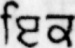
ਇਕ
